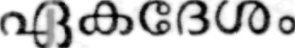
ഏകദേശം
